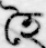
হৈ
